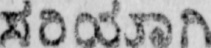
ಸರಿಯಾಗಿ
